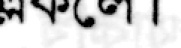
হল্লকলে
